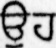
ਉਹ
